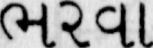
ભરવા
